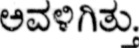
ಅವಳಿಗಿತ್ತು.
